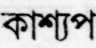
কাশ্যপ
